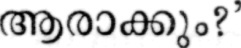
ആരാക്കും?'
